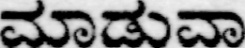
ಮಾಡುವಾ
